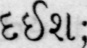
દઇશ;
